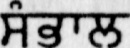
ਸੰਭਾਲ
